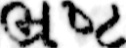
ભ્રષ્ટ
